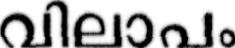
വിലാപം
